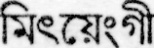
মিৎয়েংগী
